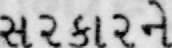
સરકારને
